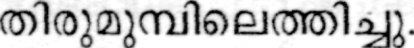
തിരുമുമ്പിലെത്തിച്ചു.
